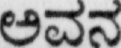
ಅವನ
